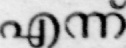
എന്ന്
